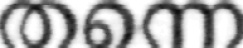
തന്നെ
